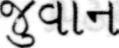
જુવાન
